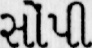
સોંપી
